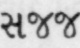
સજજ
